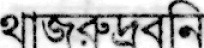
থাজরুদ্রবনি
